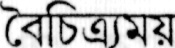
বৈচিত্র্যময়
